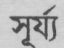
সূৰ্য্য
